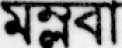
মম্লবা
